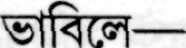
ভাবিলে-
